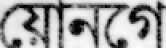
য়োনগে
